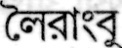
লৈরাংবু
